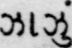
ઝાઝું
